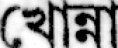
খোন্না
